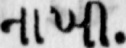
નાખી.
